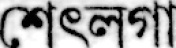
শেৎলগা
